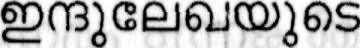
ഇന്ദുലേഖയുടെ
